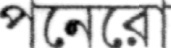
পনেরো
